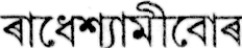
ৰাধেশ্যামীবোৰ
